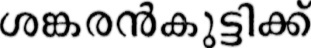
ശങ്കരന്‍കുട്ടിക്ക്
